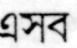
এসব
